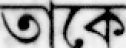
তাকে
